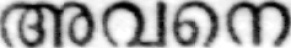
അവനെ
